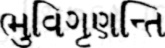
ભુવિગૃણન્તિ
